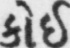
કોઈ
